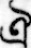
ঐ
